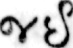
જઈ
